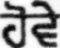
ਹੋਵੇ
